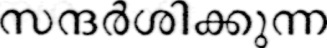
സന്ദര്‍ശിക്കുന്ന
